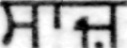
ਸਾਜ਼
